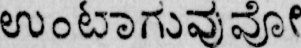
ಉಂಟಾಗುವುವೋ
